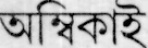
অম্বিকাই
